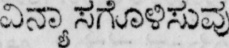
ವಿನ್ಯಾಸಗೊಳಿಸುವು
